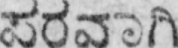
ಪರವಾಗಿ
